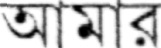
আমার
